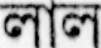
লাল
